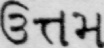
ઉત્તમ
